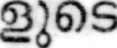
ളുടെ
